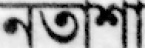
নতাশা
